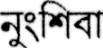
নুংশিবা
